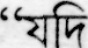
"যদি
